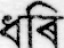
ধৰি
